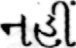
નહીં
